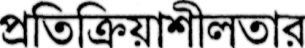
প্রতিক্রিয়াশীলতার
